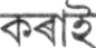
কৰাই
